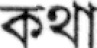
কথা
